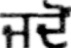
ਜਦੋਂ
